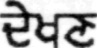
ਦੇਖਣ
